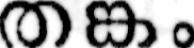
തങ്കം
